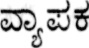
ವ್ಯಾಪಕ
